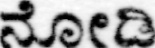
ನೋಡಿ
